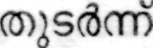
തുടര്‍ന്ന്
